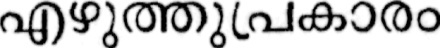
എഴുത്തുപ്രകാരം
